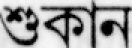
শুকান
